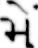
મે
